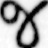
જ
